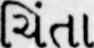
ચિંતા
